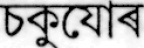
চকুযোৰ
